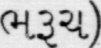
ભરૂચ)
